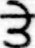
ਤੇ
